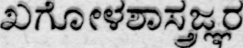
ಖಗೋಳಶಾಸ್ತ್ರಜ್ಞರ
